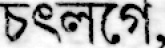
চৎলগে,
